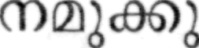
നമുക്കു
